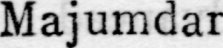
Majumdar
